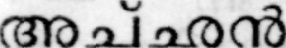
അച്ഛന്‍
